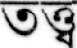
তত্ত্ব
